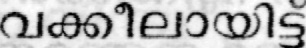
വക്കീലായിട്ട്
